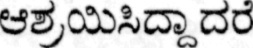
ಆಶ್ರಯಿಸಿದ್ದಾದರೆ
